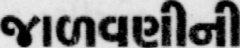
જાળવણીની
